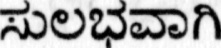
ಸುಲಭವಾಗಿ
